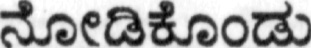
ನೋಡಿಕೊಂಡು
